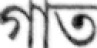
গাত
